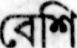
বেশি
